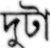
দুটা
